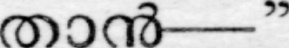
താന്‍-”
